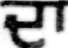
ਦਾ
